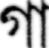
গা
